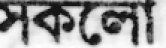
সকলো
